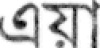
এয়া
